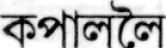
কপাললৈ
